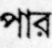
পার
